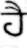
ਹੈ
